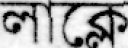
লাক্লে
